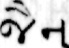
જૈન
